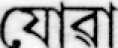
যোৱা
